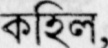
কহিল,
